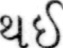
થઈ
